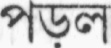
পড়ল
